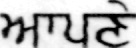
ਆਪਣੇ
